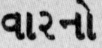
વારનો
